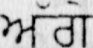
ਅੱਗੇ
